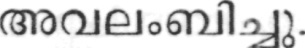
അവലംബിച്ചു.
